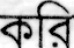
করি
